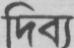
দিব্য
